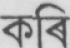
কৰি
